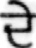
ਦੇ
